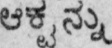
ಆಕ್ಟ್‌ನ್ನು
